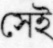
সেই
